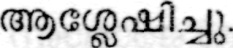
ആശ്ലേഷിച്ചു.
